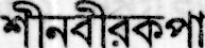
শীনবীরকপা
